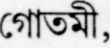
গোতমী,
